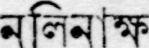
নলিনাক্ষ
